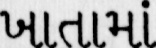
ખાતામાં
